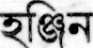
হঞ্জিন
